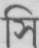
সি
